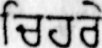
ਚਿਹਰੇ
